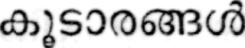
കൂടാരങ്ങള്‍
